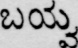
ಬಯ್ವ
